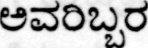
ಅವರಿಬ್ಬರ
